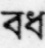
বধ
